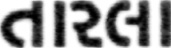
તારલા
